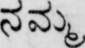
ನಮ್ಮ
